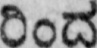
ರಿಂದ
